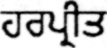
ਹਰਪ੍ਰੀਤ
